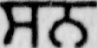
ਸਨ
